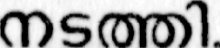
നടത്തി.
